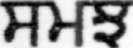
ਸਮਝ
